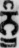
ਨੂੰ
